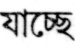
যাচ্ছে
